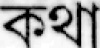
কথা
